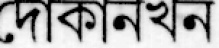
দোকানখন
